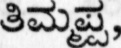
ತಿಮ್ಮಪ್ಪ,
